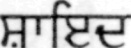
ਸ਼ਾਇਦ
